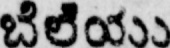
ಬೆಲೆಯು
